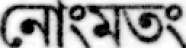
নোংমতং
